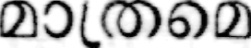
മാത്രമെ
